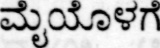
ಮೈಯೊಳಗೆ
